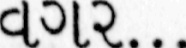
વગર...
